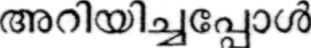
അറിയിച്ചപ്പോള്‍
